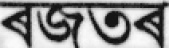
ৰজতৰ
